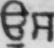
ਉਸ
